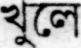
খুলে
